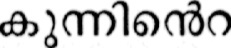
കുന്നിന്റെ
